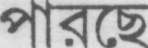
পারছে
